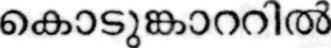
കൊടുങ്കാററില്‍
